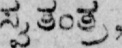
ಸ್ವತಂತ್ರ,
